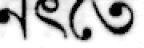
নৎতে
